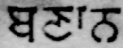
ਬਣਾਨ
